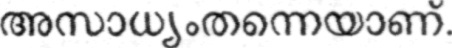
അസാധ്യംതന്നെയാണ്.
